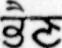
ਭੈਣ
